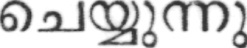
ചെയ്യുന്നു
